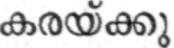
കരയ്ക്കു
